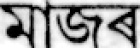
মাজৰ
